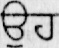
ਉਹ
